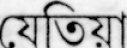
যেতিয়া
